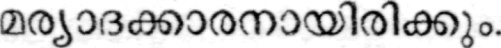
മര്യാദക്കാരനായിരിക്കും.
